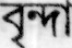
বৃন্দা
